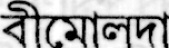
বীমোলদা
